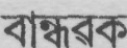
বান্ধৱক
